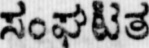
ಸಂಘಟಿತ
